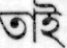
তাই
